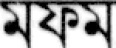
মফম
